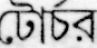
টোর্চর
